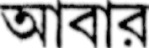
আবার
